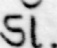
ડૉ.
